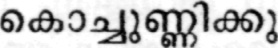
കൊച്ചുണ്ണിക്കു
